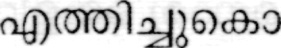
എത്തിച്ചുകൊ
